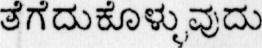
ತೆಗೆದುಕೊಳ್ಳುವುದು
